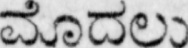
ಮೊದಲು
